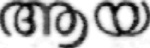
ആയ
